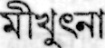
মীখুৎনা
